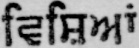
ਵਿਸ਼ਿਆਂ
